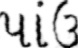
પાંઉ
